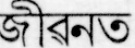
জীৱনত
